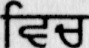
ਵਿਚ
